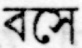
বসে
